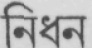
নিধন
